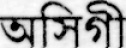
অসিগী
